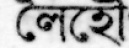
ৱাফমদু
